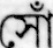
সোঁ
